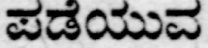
ಪಡೆಯುವ
